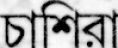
চাশিরা
